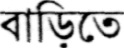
বাড়িতে
